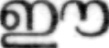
ഈ
